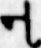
ન
